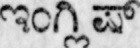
ಇಂಗ್ಲಿಷ್
